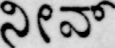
ನೀವ್
